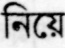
নিয়ে
